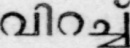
വിറച്ച്
